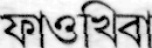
ফাওখিবা
